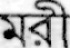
মরী
